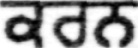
ਕਰਨ
